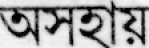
অসহায়
